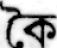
কৈ
